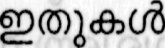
ഇതുകള്‍
